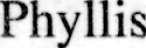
Phylis
